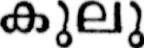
കുലു
